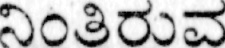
ನಿಂತಿರುವ
